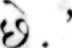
છે.'
